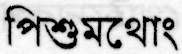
পিশুমথোং
